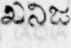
ಖನಿಜ
